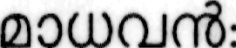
മാധവന്‍:
